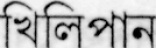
খিলিপান
